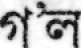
গ'ল
